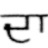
ਦਾ
